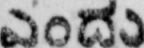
ಎಂದು
